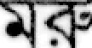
মরু
